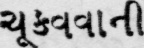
ચૂકવવાની
